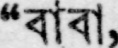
‘‘বাবা,
